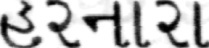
હરનારા
